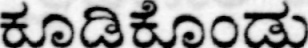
ಕೂಡಿಕೊಂಡು
